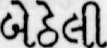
બેઠેલી
